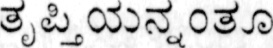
ತೃಪ್ತಿಯನ್ನಂತೂ
